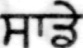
ਸਾਡੇ
